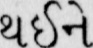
થઈને
